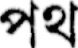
পথ
